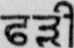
ਫੜੀ
